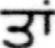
ਤਾਂ
